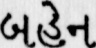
બહેન
